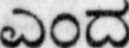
ಎಂದ
